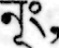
নূং,
